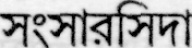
সংসারসিদা
